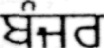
ਬੰਜਰ
